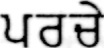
ਪਰਚੇ
